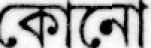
কোনো
